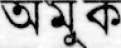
অমুক
